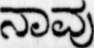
ನಾವು
